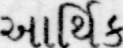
આર્થિક
